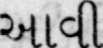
આવી
